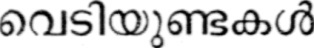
വെടിയുണ്ടകള്‍
